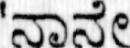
‘ನಾನೇ
